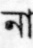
না
